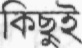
কিছুই
